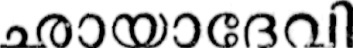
ഛായാദേവി
